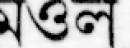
মওল
